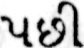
પછી
